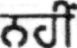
ਨਹੀਂ
